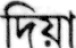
দিয়া
